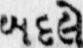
બદલે
